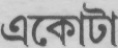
একোটা
